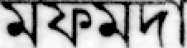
মফমদা
